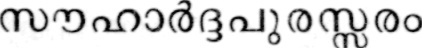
സൌഹാര്‍ദ്ദപുരസ്സരം
